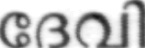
ദേവി
